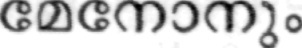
മേനോനും
